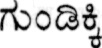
ಗುಂಡಿಕ್ಕಿ
